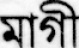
মাগী
